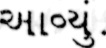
આવ્યું.
